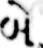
બે
